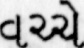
વચ્ચે
